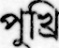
পুখ্রি
